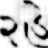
રહે
